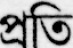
প্রতি
